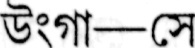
উংগা–সে
